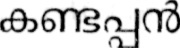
കണ്ടപ്പന്‍
